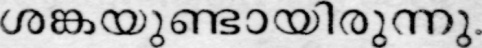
ശങ്കയുണ്ടായിരുന്നു.
